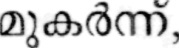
മുകര്‍ന്ന്,
